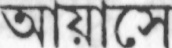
আয়াসে
